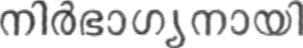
നിര്‍ഭാഗ്യനായി
